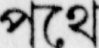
পথে
